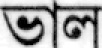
ভাল
